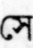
সে
